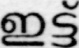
ഇട്ട്
